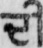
ਦੀ
